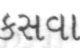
કસવા
